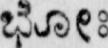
ಭೋಃ
